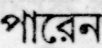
পারেন
